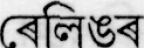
ৰেলিঙৰ
